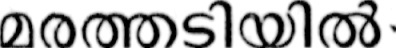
മരത്തടിയില്‍
